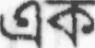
এক
